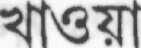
খাওয়া
